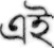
এই
